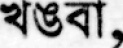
খঙবা,
